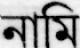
নামি
